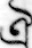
ঐ
